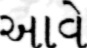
આવે
